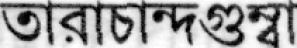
তারাচান্দগুম্বা
